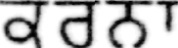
ਕਰਨਾ
